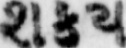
શક્ય
